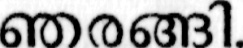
ഞരങ്ങി.
